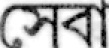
সেবা
